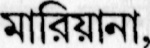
মারিয়ানা,
